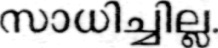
സാധിച്ചില്ല.
